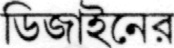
ডিজাইনের
